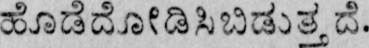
ಹೊಡೆದೋಡಿಸಿಬಿಡುತ್ತದೆ.
